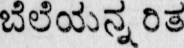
ಬೆಲೆಯನ್ನರಿತ
